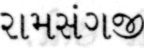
રામસંગજી
